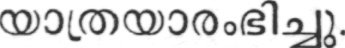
യാത്രയാരംഭിച്ചു.
